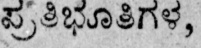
ಪ್ರತಿಭೂತಿಗಳ,
